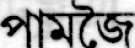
পামজৈ
